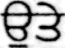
ਉਤੇ
